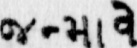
જન્માવે
